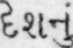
દેશનું
